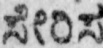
ಸೇರಿಸ
